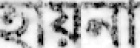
হায়না
